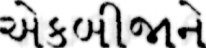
એકબીજાને
